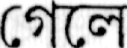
গেলে
